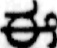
ಈ
